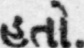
હતો.
